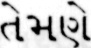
તેમણે
